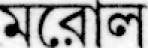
মরোল
